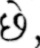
છે,
